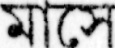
মাসে
